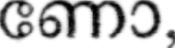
ണോ,
